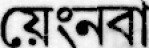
য়েংনবা
